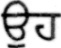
ਉਹ
